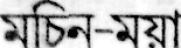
মচিন-ময়া
